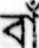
বাঁ
